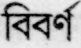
বিবর্ণ
